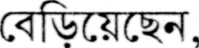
বেড়িয়েছেন,
